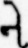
ને
